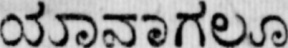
ಯಾವಾಗಲೂ
